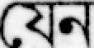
যেন
